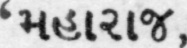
'મહારાજ,
